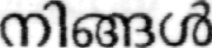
നിങ്ങള്‍
